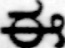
ಈ
